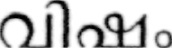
വിഷം
